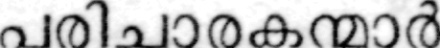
പരിചാരകന്മാര്‍
